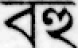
বহু
